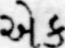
એક
